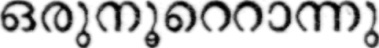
ഒരുനൂറ്റൊന്നു
